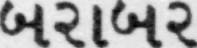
બરાબર
